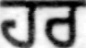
ਹਰ
